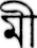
মী
